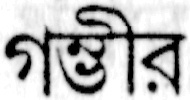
গম্ভীর
